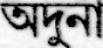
অদুনা
